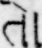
તો
